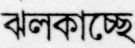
ঝলকাচ্ছে
